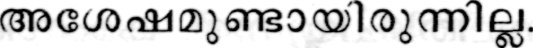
അശേഷമുണ്ടായിരുന്നില്ല.
